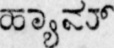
ಹ್ಯಾಮ್
